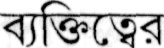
ব্যক্তিত্বের
